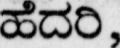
ಹೆದರಿ,
